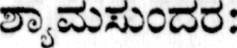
ಶ್ಯಾಮಸುಂದರ:
